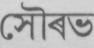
সৌৰভ
